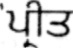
'ਪ੍ਰੀਤ
